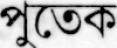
পুতেক
